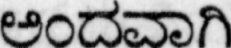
ಅಂದವಾಗಿ
